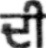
ਦੀ
